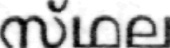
സ്ഥല
